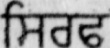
ਸਿਰਫ
